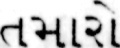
તમારો
